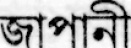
জাপানী
